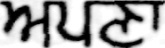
ਅਪਣਾ
